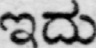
ಇದು
